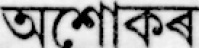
অশোকৰ
